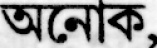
অনোক,
